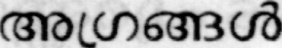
അഗ്രങ്ങള്‍
